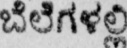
ಬೆಲೆಗಳಲ್ಲಿ
